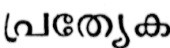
പ്രത്യേക
